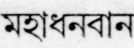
মহাধনবান
